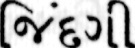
જિંદગી
